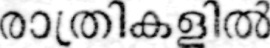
രാത്രികളില്‍
